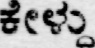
ಕೇಳ್ದು
